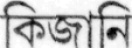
কিজানি
